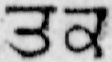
ਤਕ
